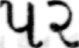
પર
